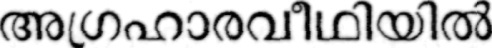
അഗ്രഹാരവീഥിയില്‍
